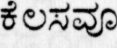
ಕೆಲಸವೂ
